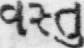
વસ્તુ
